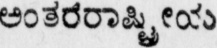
ಅಂತರರಾಷ್ಟ್ರೀಯ
